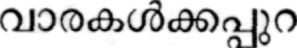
വാരകള്‍ക്കപ്പുറ
